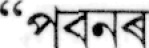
"পবনৰ
